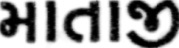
માતાજી
